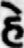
હે
